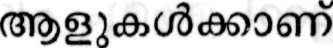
ആളുകള്‍ക്കാണ്
